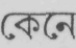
কেনে
